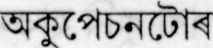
অকুপেচনটোৰ
